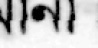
মানা
